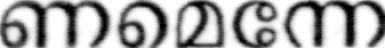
ണമെന്നേ
